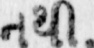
નથી.
